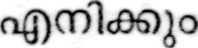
എനിക്കും
